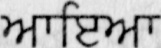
ਆਇਆ
